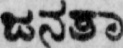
ಜನತಾ
